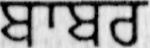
ਬਾਬਰ
